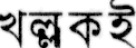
খল্লকই
